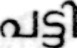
പട്ടി
